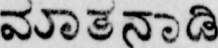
ಮಾತನಾಡಿ
